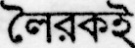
লৈরকই
